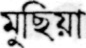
মুছিয়া
